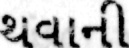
થવાની
